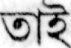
তাই
